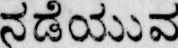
ನಡೆಯುವ
